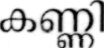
കണ്ണി
